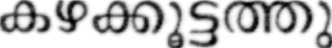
കഴക്കൂട്ടത്തു
